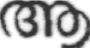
ആ
